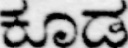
ಕೂಡ
